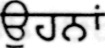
ਉਹਨਾਂ
